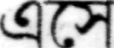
এসে
